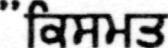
''ਕਿਸਮਤ
